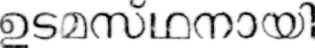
ഉടമസ്ഥനായി
